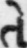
તે
